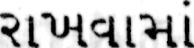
રાખવામાં
